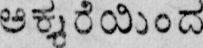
ಅಕ್ಕರೆಯಿಂದ
